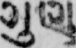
ગુણ
